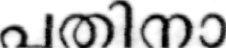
പതിനാ
